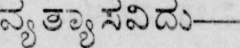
ವ್ಯತ್ಯಾಸವಿದು-
